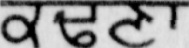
ਕਢਣਾ
